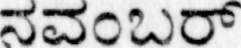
ನವಂಬರ್
